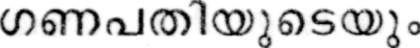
ഗണപതിയുടെയും
